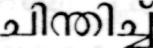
ചിന്തിച്ച്
